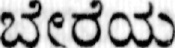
ಬೇರೆಯ
